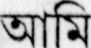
আমি
